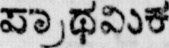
ಪ್ರಾಥಮಿಕ
